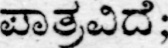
ಪಾತ್ರವಿದೆ;
